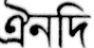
ঐনদি
